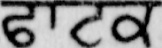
ਫਾਟਕ
